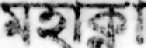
মহাক্না
